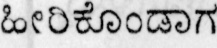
ಹೀರಿಕೊಂಡಾಗ
